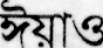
ঈয়াও
